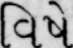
વિષે
